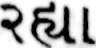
રહ્યા
